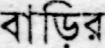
বাড়ির
